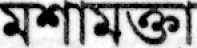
মশামক্তা
